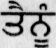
ਤੈਨੂੰ
